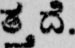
ತ್ತದೆ.
